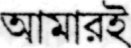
আমারই
